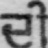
ਦੀ
